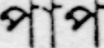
পাপ
